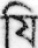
যি
